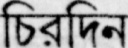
চিরদিন
